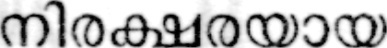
നിരക്ഷരയായ
